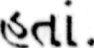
હતાં.
